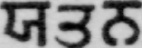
ਯਤਨ
